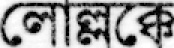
লোল্লক্কে
